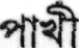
পাখী
